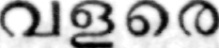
വളരെ
